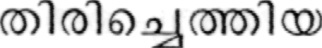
തിരിച്ചെത്തിയ
